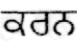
ਕਰਨ
